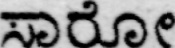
ಸಾರೋ
